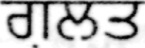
ਗ਼ਲਤ
